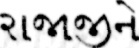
રાજાજીને
